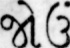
જોઉં
